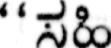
"ಸಹಿ
